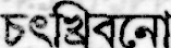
চৎখ্রিবনো
